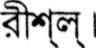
রীশ্‌ল্।
